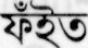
ফঁইত
